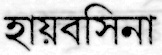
হায়বসিনা
